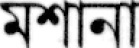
মশানা
